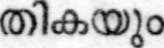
തികയും
